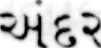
અંદર
